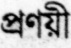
প্রণয়ী
